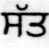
ਸੱਤ
